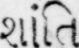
શાંતિ
